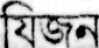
যিজন
